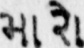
મારો
